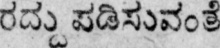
ರದ್ದುಪಡಿಸುವಂತೆ
